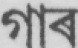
গাৰ
